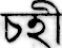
চহী
